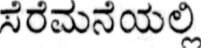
ಸೆರೆಮನೆಯಲ್ಲಿ
